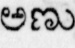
ಅಣು
